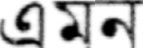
এমন
